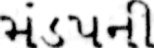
મંડપની
